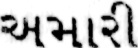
અમારી
